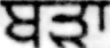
ਬੜਾ
